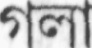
গলা
